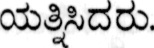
ಯತ್ನಿಸಿದರು.
